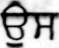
ਉਸ
